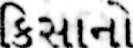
કિસાનો
